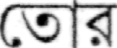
তোর
